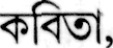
কবিতা,
